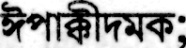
ঈপাক্কীদমক;
